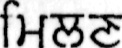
ਮਿਲਣ
